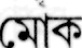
মোক
